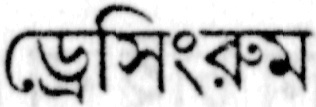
ড্রেসিংরুম
